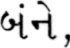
બંને,
